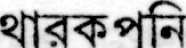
থারকপনি
